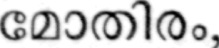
മോതിരം,
